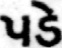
પડે
